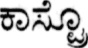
ಕಾಸ್ಟ್ರೂ
